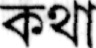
কথা
